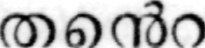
തന്റെ
